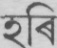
হৰি
